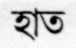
হাত
